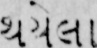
થયેલા
